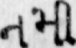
નમી
